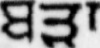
ਬੜਾ
